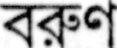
বরুণ
